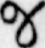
જ
